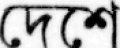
দেশে
